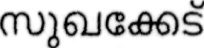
സുഖക്കേട്
